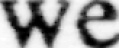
we
